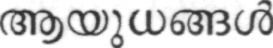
ആയുധങ്ങള്‍
